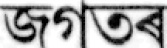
জগতৰ
